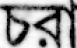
চরা
